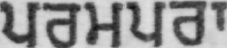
ਪਰਮਪਰਾ
